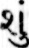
શું
